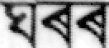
ঘৰৰ
